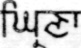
ਘ੍ਰਿਣਾ
